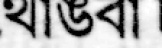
থোঙবা
